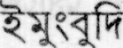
ইমুংবুদি
